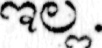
ಇಲ್ಲ.
